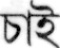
চাই
